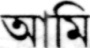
আমি
